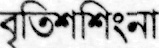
বৃতিশশিংনা
